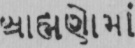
બ્રાહ્મણોમાં
